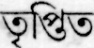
তৃপ্তিত
